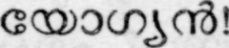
യോഗ്യന്‍!
